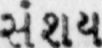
સંશય
